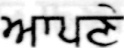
ਆਪਣੇ
